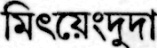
মিৎয়েংদুদা
